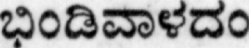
ಭಿಂಡಿವಾಳದಂ
